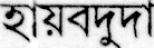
হায়বদুদা
